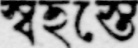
স্বহস্তে
